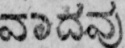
ವಾದವು
